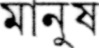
মানুষ
